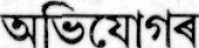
অভিযোগৰ
